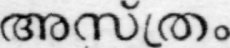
അസ്ത്രം
